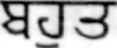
ਬਹੁਤ
